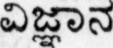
ವಿಜ್ಞಾನ
